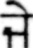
ਜੇ
